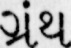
ગ્રંથ
